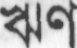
ঋণ
